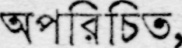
অপরিচিত,
